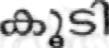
കൂടി
